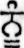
ਨੂੰ
